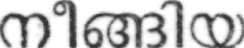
നീങ്ങിയ
